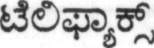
ಟೆಲಿಫ್ಯಾಕ್ಸ್
